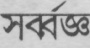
সৰ্ব্বজ্ঞ
